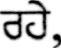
ਰਹੇ,
